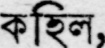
কহিল,
